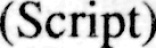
(Script)
